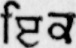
ਇਕ
